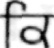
ਕਿ
